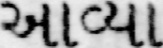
આવ્યા
